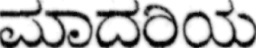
ಮಾದರಿಯ
